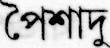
পৈশাদু
